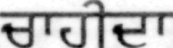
ਚਾਹੀਦਾ
